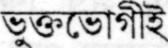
ভুক্তভোগীই
